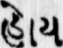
હોય
